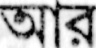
আর
